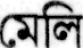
মেলি
